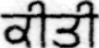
ਕੀਤੀ
